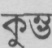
কুম্ভ
